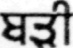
ਬੜੀ
